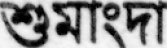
শুমাংদা
